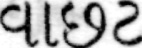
વાછટ
